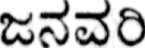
ಜನವರಿ
